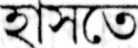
হাসতে
